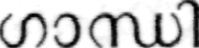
ഗാന്ധി
